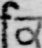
ਕਿ
